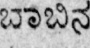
ಬಾಬಿನ
